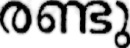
രണ്ടു
